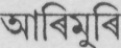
আৰিমুৰি
